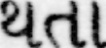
થતા
